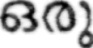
ഒരു
